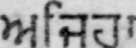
ਅਜਿਹਾ
